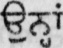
ਉਨ੍ਹਾਂ
